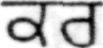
ਕਰ
